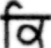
ਕਿ
